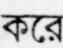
করে
